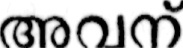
അവന്
